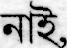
নাই,
